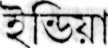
ইন্ডিয়া
